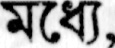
মধ্যে,
